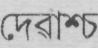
দেৱাশ্চ
